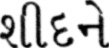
શીદને
